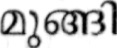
മുങ്ങി
